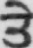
ਤੇ
